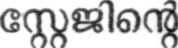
സ്റ്റേജിന്റെ
